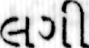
લગી
